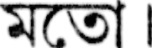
মতো।
